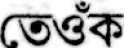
তেওঁক
